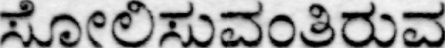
ಸೋಲಿಸುವಂತಿರುವ
